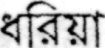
ধরিয়া
